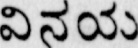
ವಿನಯ
